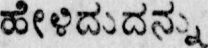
ಹೇಳಿದುದನ್ನು
